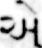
એ
